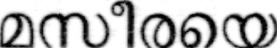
മസീരയെ
